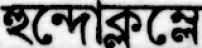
হুন্দোক্লম্লে
